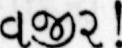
વજીર!
